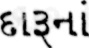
દારૂનાં
